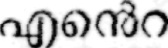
എന്റെ
